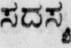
ಸದಸ್ಯ
